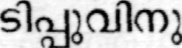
ടിപ്പുവിനു
